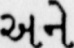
અને
